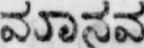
ಮಾನವ
